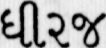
ધીરજ
